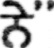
ਨੇ''
